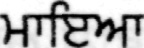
ਮਾਇਆ
